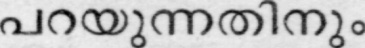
പറയുന്നതിനും
